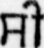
ਸੀ
